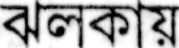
ঝলকায়
